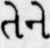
તેને
